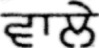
ਵਾਲੇ
